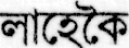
লাহেকৈ
